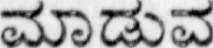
ಮಾಡುವ
